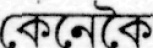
কেনেকৈ
